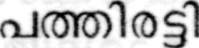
പത്തിരട്ടി
